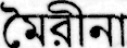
মৈরীনা
